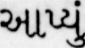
આપ્યું
